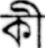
কী
